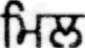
ਮਿਲ
